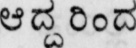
ಆದ್ದರಿಂದ
